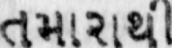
તમારાથી
